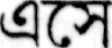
এসে
